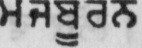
ਮਜਬੂਰਨ
